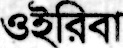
ওইরিবা
